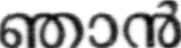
ഞാന്‍
